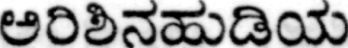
ಅರಿಶಿನಹುಡಿಯ
